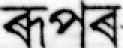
ৰূপৰ
